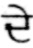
ਦੇ
